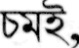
চমই,
